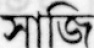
সাজি
